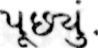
પૂછ્યું.
